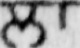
ਲਾ
